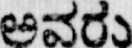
ಅವರು
